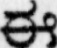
ಈ
